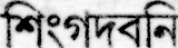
শিংগদবনি
